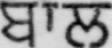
ਬਾਲ
